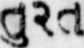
તુરત
